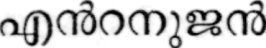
എന്റനുജന്‍
